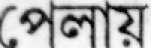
পেলায়
